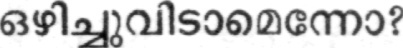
ഒഴിച്ചുവിടാമെന്നോ?
